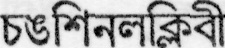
চঙশিনলক্লিবী
